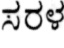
ಸರಳ
